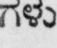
ಗಳು
